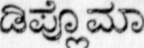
ಡಿಪ್ಲೊಮಾ
